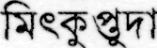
মিৎকুপ্তুদা
